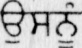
ਉਸਨੂੰ
